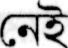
নেই
